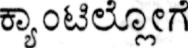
ಕ್ಯಾಂಟಿಲ್ಲೋಗೆ
